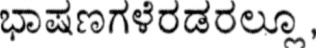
ಭಾಷಣಗಳೆರಡರಲ್ಲೂ,
